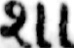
શા
